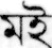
মই
